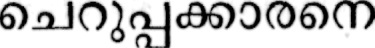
ചെറുപ്പക്കാരനെ
